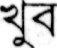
খুব
